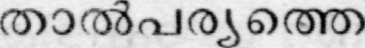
താല്‍പര്യത്തെ
